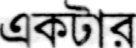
একটার
